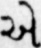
એ
